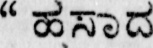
“ಹಸಾದ
